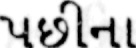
પછીના
